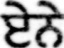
ਏਨੇ
